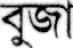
বুজা
